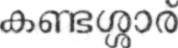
കണ്ടശ്ശാര്
